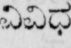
ವಿವಿಧ
